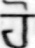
ਹੋ
